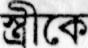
স্ত্রীকে
